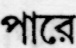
পারে
